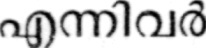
എന്നിവര്‍
